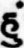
હું
